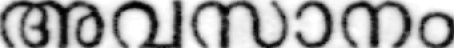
അവസാനം
